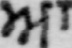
ਆ
